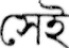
সেই
